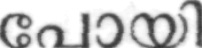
പോയി
